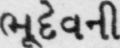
ભૂદેવની
